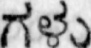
ಗಳು
